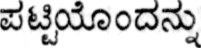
ಪಟ್ಟಿಯೊಂದನ್ನು
